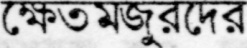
ক্ষেতমজুরদের
